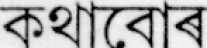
কথাবোৰ
